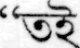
"তই
